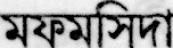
মফমসিদা
